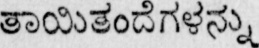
ತಾಯಿತಂದೆಗಳನ್ನು
